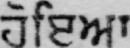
ਹੋਇਆ
